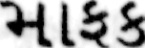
માફક
